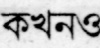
কখনও
